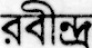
রবীন্দ্র
